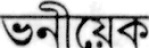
ভনীয়েক
